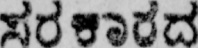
ಸರಕಾರದ
